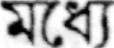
মধ্যে
